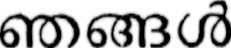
ഞങ്ങള്‍
